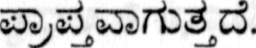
ಪ್ರಾಪ್ತವಾಗುತ್ತದೆ.
